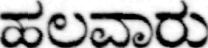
ಹಲವಾರು
